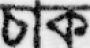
চাক
